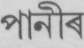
পানীৰ
